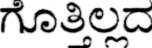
ಗೊತ್ತಿಲ್ಲದ
